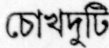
চোখদুটি
